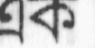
এক
